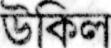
উকিল
